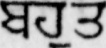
ਬਹੁਤ
